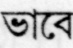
ভাবে
